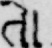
તો
